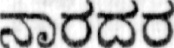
ನಾರದರ
